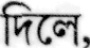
দিলে,
